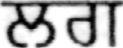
ਲਗ
